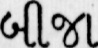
બીજા
